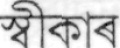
স্বীকাৰ
